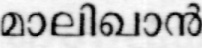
മാലിഖാന്‍
